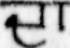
ਦਾ
